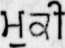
ਮੁਕੀ
